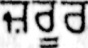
ਜ਼ਰੂਰ
